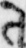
તે
